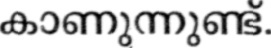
കാണുന്നുണ്ട്.
